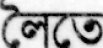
লৈতে
